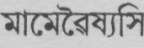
মামেৱৈষ্যসি
